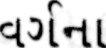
વર્ગના
